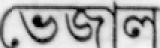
ভেজাল
